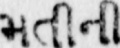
મતીની
